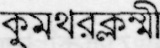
কুমথরক্লম্মী
